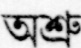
অশ্রু
